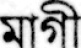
মাগী
